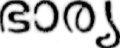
ഭാര്യ
